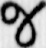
જ
